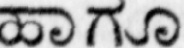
ಹಾಗೂ
